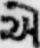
એ
